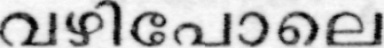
വഴിപോലെ
